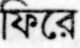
ফিরে
